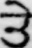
ਤੇ
